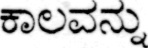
ಕಾಲವನ್ನು
